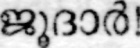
ജൂദാര്‍!
